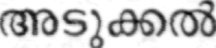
അടുക്കല്‍
